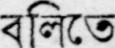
বলিতে
